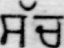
ਸੱਚ
